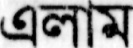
এলাম
